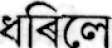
ধৰিলে
